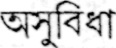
অসুবিধা
